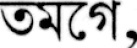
তমগে,
